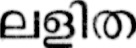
ലളിത
